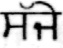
ਸੱਜੇ
